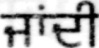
ਜਾਂਦੀ
